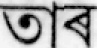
তাৰ
